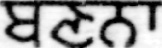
ਬਣਨਾ
